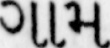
ગામ
